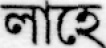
লাহে
